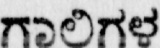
ಗಾಲಿಗಳ
